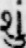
શું
